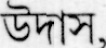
উদাস,
